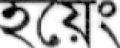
হয়েং
